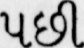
પછી
